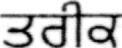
ਤਰੀਕ
